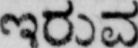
ಇರುವ
